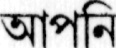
আপনি
